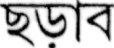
ছড়াব
